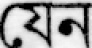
যেন
